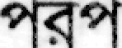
পরপ
